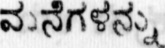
ಮನೆಗಳನ್ನು
